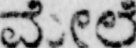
ಮೇಲೆ
